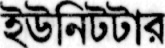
ইউনিটটার
